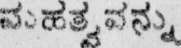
ಮಹತ್ವವನ್ನು
